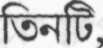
তিনটি,
